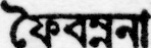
ফৈবম্ননা
